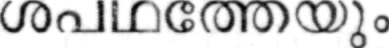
ശപഥത്തേയും
